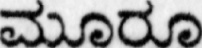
ಮೂರೂ
